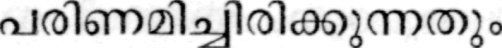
പരിണമിച്ചിരിക്കുന്നതും
